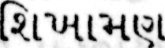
શિખામણ
